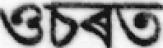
ওচৰত
